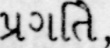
પ્રગતિ,
